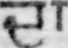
ਦਾ
